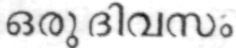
ഒരുദിവസം
